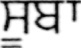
ਸੂਬਾ
